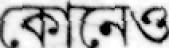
কোনেও
